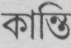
কান্তি
